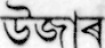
উজাৰ
